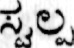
ಸ್ವಲ್ಪ
